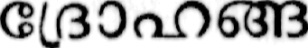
ദ്രോഹങ്ങ
